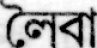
লৈবা
